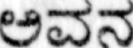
ಅವನ
